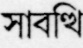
সাবত্থি
